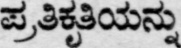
ಪ್ರತಿಕೃತಿಯನ್ನು
